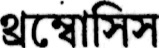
থ্রম্বোসিস
